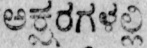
ಅಕ್ಷರಗಳಲ್ಲಿ
